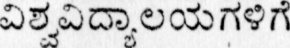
ವಿಶ್ವವಿದ್ಯಾಲಯಗಳಿಗೆ
